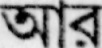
আর
